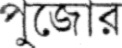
পুজোর
